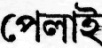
পেলাই
